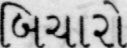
બિચારો
